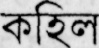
কহিল
